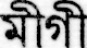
মীগী
